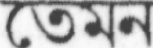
তেমন
